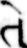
તે
